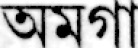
অমগা
